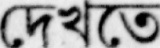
দেখতে
